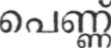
പെണ്ണ്
